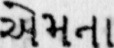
એમના
